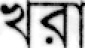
খরা
